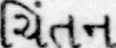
ચિંતન
